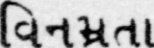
વિનમ્રતા
